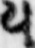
ય
